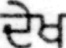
ਦੇਖ
